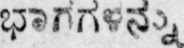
ಭಾಗಗಳನ್ನು
